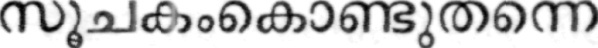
സൂചകംകൊണ്ടുതന്നെ
